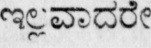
ಇಲ್ಲವಾದರೇ
